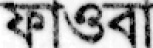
ফাওবা
